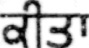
ਕੀਤਾ
